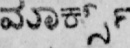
ಮಾರ್ಕ್ಸ್
